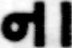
ના
